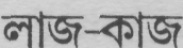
লাজ-কাজ
